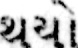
થયો
